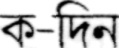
ক-দিন
